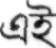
এই
